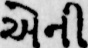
એની
